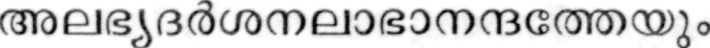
അലഭ്യദര്‍ശനലാഭാനന്ദത്തേയും
